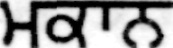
ਮਕਾਨ
